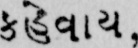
કહેવાય,
